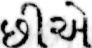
છીએ
